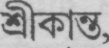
শ্রীকান্ত,
